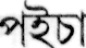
পইচা
